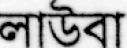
লাউবা
